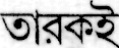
তারকই
